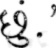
છું.'
